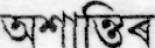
অশান্তিৰ
